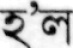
হ'ল
